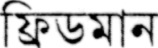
ফ্রিডমান
